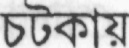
চটকায়
